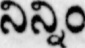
ನಿನ್ನಿಂ
